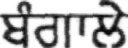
ਬੰਗਾਲੇ
